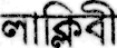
লাক্লিবী
